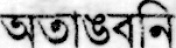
অতাঙবনি
